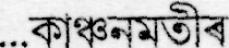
...কাঞ্চনমতীৰ
